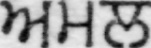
ਅਮਲ
